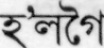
হ'লগৈ
